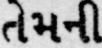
તેમની
